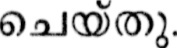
ചെയ്തു.
